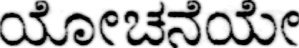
ಯೋಚನೆಯೇ
